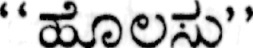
"ಹೊಲಸು"
